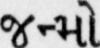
જન્મો
